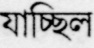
যাচ্ছিল
